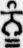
ਨੂੰ
